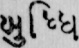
બુધ્ધિ
